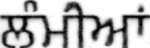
ਲੰਮੀਆਂ
